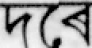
দৰে
